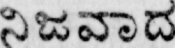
ಜವಾದ
